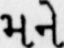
મને
